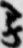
કે
